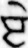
ਏ
